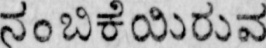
ನಂಬಿಕೆಯಿರುವ
